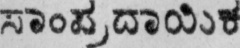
ಸಾಂಪ್ರದಾಯಿಕ
